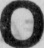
O
